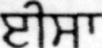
ਈਸਾ
